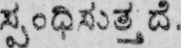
ಸ್ಪಂಧಿಸುತ್ತದೆ.
